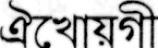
ঐখয়োগী
